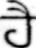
ਹੈ
